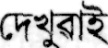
দেখুৱাই
